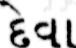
દેવા
